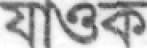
যাওক
